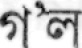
গ'ল
